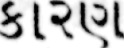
કારણ
